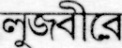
লুজবীরে
